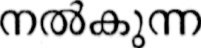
നല്‍കുന്ന
